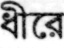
ধীরে
